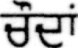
ਚੌਦਾ
